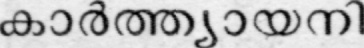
കാര്‍ത്ത്യായനി
